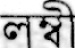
লম্বী
